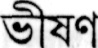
ভীষণ
